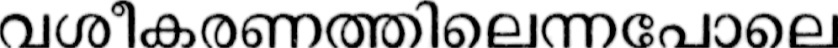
വശീകരണത്തിലെന്നപോലെ
